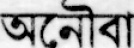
অনৌবা
